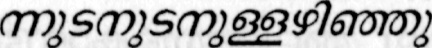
ന്നുടനുടനുള്ളഴിഞ്ഞു
